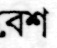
বেশ
